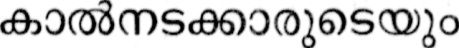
കാല്‍നടക്കാരുടെയും
